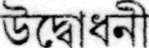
উদ্বোধনী
